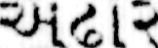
અઢાર
